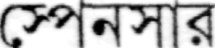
স্পেনসার
